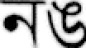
নঙ
